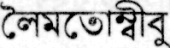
লৈমতোম্বীবু
